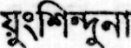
য়ুংশিন্দুনা
